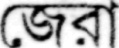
জেরা
